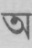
অ'
